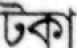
টকা
